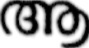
ആ
